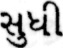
સુધી
